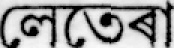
লেতেৰা
